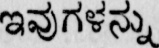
ಇವುಗಳನ್ನು
